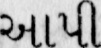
આપી
